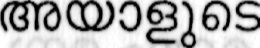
അയാളുടെ
